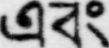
এবং
